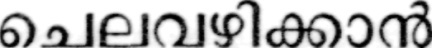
ചെലവഴിക്കാന്‍
